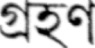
গ্রহণ
